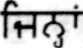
ਜਿਨ੍ਹਾਂ
